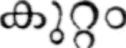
കുറ്റം
